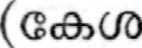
(കേശ
